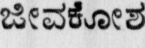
ಜೀವಕೋಶ
